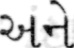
અને
